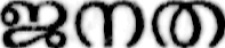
ജനത
